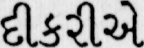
દીકરીએ
